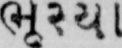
ભૂસ્યા
